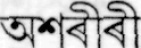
অশৰীৰী
